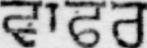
ਵਾਫਰ
